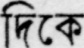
দিকে
